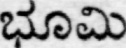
ಭೂಮಿ
